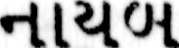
નાયબ
